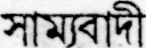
সাম্যবাদী
